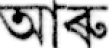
আৰু
